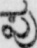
ಪು
